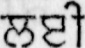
ਲਈ
